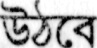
উঠবে
